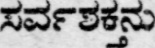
ಸರ್ವಶಕ್ತನು
